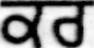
ਕਰ
